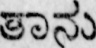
ತಾನು
